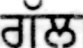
ਗੱਲ
